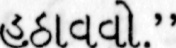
હઠાવવો."
